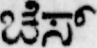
ಚೆಸ್
